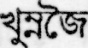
খুম্নজৈ
